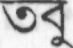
তবু
